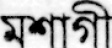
মশাগী
